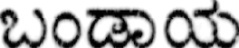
ಬಂಡಾಯ
